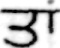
ਤਾਂ
